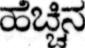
ಹೆಚ್ಚಿನ
